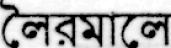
লৈরমালে
